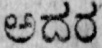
ಅದರ
